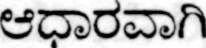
ಆಧಾರವಾಗಿ
